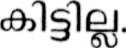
കിട്ടില്ല.
